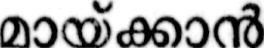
മായ്ക്കാന്‍
